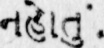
નહોતું.
